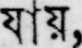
যায়,
